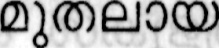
മുതലായ
